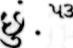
છું.૫૩
